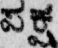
ಪಕ್ಷ
